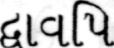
દ્વાવપિ
